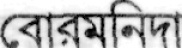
বোরমনিদা
